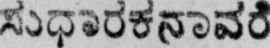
ಸುಧಾರಕನಾವರೆ
